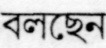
বলছেন
